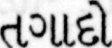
તગાદો
